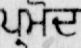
ਪ੍ਰਮੋਦ
